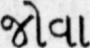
જોવા
